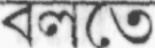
বলতে
